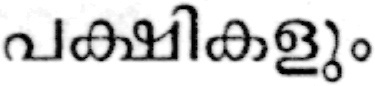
പക്ഷികളും
